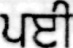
ਪਈ
